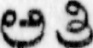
ಅತಿ
